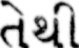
તેથી
